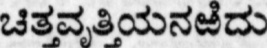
ಚಿತ್ತವೃತ್ತಿಯನಱದು
